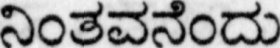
ನಿಂತವನೆಂದು
